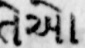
તેઓ
